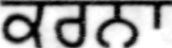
ਕਰਨਾ
